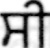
ਸੀ
